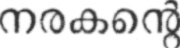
നരകന്റെ
